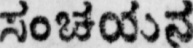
ಸಂಚಯನ
